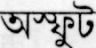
অস্ফুট
